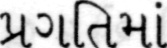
પ્રગતિમાં
